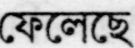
ফেলেছে
